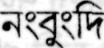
নংবুংদি
